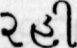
રહી
